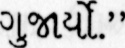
ગુજાર્યો."
